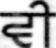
ਵੀ
